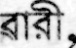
ৱারী,
